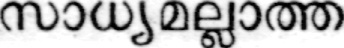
സാധ്യമല്ലാത്ത
